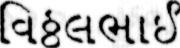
વિઠ્ઠલભાઈ
